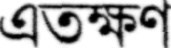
এতক্ষণ
